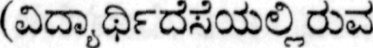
(ವಿದ್ಯಾರ್ಥಿದೆಸೆಯಲ್ಲಿರುವ
